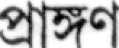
প্রাঙ্গণ
